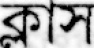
ক্লাস
